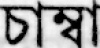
চাম্বা
